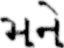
મને
